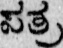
ಪತ್ರ
